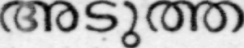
അടുത്ത
